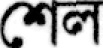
শেল
